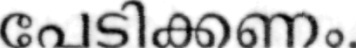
പേടിക്കണം.
